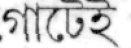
গোটেই
